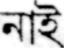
নাই
